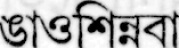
ঙাওশিন্নবা
